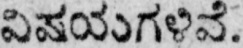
ವಿಷಯಗಳಿವೆ.
